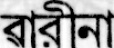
ৱারীনা
